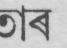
তাৰ
